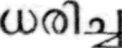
ധരിച്ച
